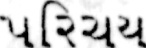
પરિચય
